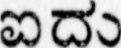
ಐದು
